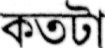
কতটা
